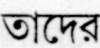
তাদের
